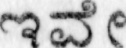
ಇವೇ
